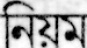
নিয়ম
